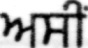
ਅਸੀਂ
